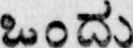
ಒಂದು
